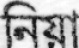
নিয়া
